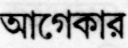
আগেকার
